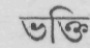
ভক্তি
